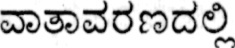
ವಾತಾವರಣದಲ್ಲಿ
